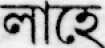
লাহে
